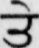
ਤੇ
